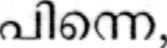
പിന്നെ,
